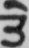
ਤੇ
